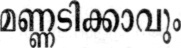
മണ്ണടിക്കാവും
